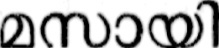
മസായി
